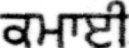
ਕਮਾਈ
